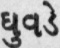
ઘુવડે
